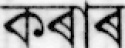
কৰাৰ
